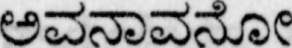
ಅವನಾವನೋ
